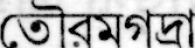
তৌরমগদ্রা
